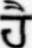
ਹੈ
